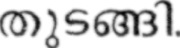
തുടങ്ങി.
